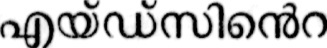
എയ്ഡ്സിന്റെ
